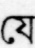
যে
